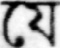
যে
